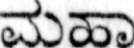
ಮಹಾ
